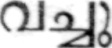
വച്ചു
